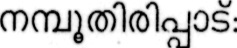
നമ്പൂതിരിപ്പാട്:
